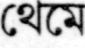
থেমে
